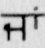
ਜਾਂ
